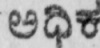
ಅಧಿಕ
